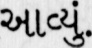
આવ્યું.
